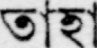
তাহা
